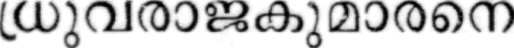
ധ്രുവരാജകുമാരനെ
